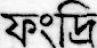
ফংদ্রি
